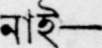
নাই—
